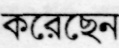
করেছেন
